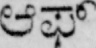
ಆಫ್
